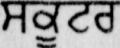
ਸਕੂਟਰ
